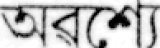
অৱশ্যে
